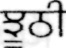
ਝੂਠੀ
